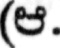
(ಆ.
